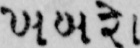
ખબરો
